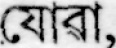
যোৱা,
